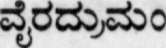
ವೈರದ್ರುಮಂ
